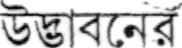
উদ্ভাবনের
